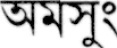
অমসুং
